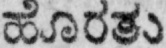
ಹೊರತು
